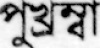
পুখ্রম্বা
